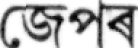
জেপৰ
